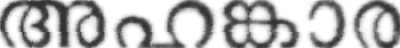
അഹങ്കാര
